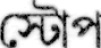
স্টোপ
